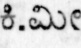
ಕಿ.ಮೀ
